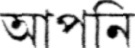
আপনি
